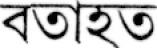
বতাহত
